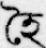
হৈ
